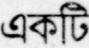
একটি
